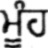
ਮੂੰਹ
